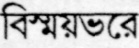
বিস্ময়ভরে
